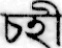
চহী
